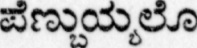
ಪೆಣ್ಬುಯ್ಯಲೊ
